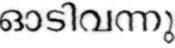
ഓടിവന്നു
